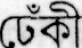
ঢেঁকী
